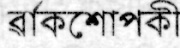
ৱার্কশোপকী
